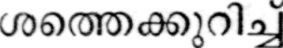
ശത്തെക്കുറിച്ച്
